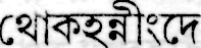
থোকহন্নীংদে
